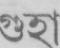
গুহা
